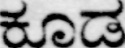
ಕೂಡ
